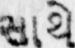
સાથે
